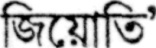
জিয়োতি’
